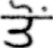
ਤੋਂ
